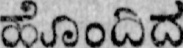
ಹೊಂದಿದ
